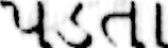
પડતા
